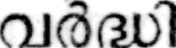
വര്‍ദ്ധി
